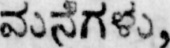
ಮನೆಗಳು,
